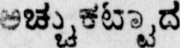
ಅಚ್ಚುಕಟ್ಟಾದ
